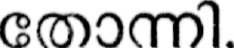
തോന്നി.
